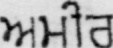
ਅਮੀਰ
